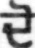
ਦੋ
